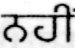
ਨਹੀਂ
